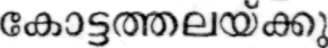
കോട്ടത്തലയ്ക്കു
